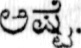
ಅಷ್ಟೆ.
